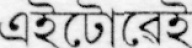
এইটোৱেই
